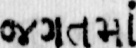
જગતમાં
